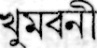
খুমবনী
